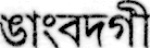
ঙাংবদগী
